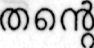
തന്റെ
